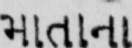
માતાના
